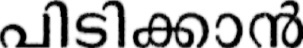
പിടിക്കാന്‍
